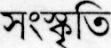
সংস্কৃতি
